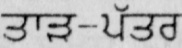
ਤਾੜ-ਪੱਤਰ
